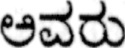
ಅವರು
